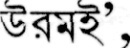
উরমই’,
